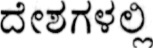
ದೇಶಗಳಲ್ಲಿ
